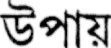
উপায়
